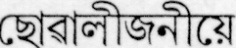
ছোৱালীজনীয়ে
